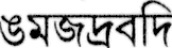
ঙমজদ্রবদি
